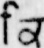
ਕਿ
